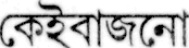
কেইবাজনো
